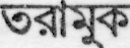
তরামুক
